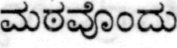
ಮಠವೊಂದು
